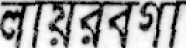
লায়রবগা
